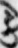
કે
